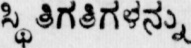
ಸ್ಥಿತಿಗತಿಗಳನ್ನು
